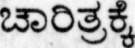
ಚಾರಿತ್ರ್ಯಕ್ಕೆ
